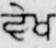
ਵੇਖ
